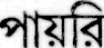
পায়রি
